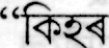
"কিহৰ
